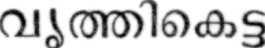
വൃത്തികെട്ട
